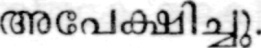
അപേക്ഷിച്ചു.
